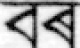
বৰ
